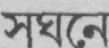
সঘনে
